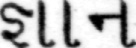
જ્ઞાન
